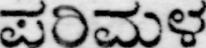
ಪರಿಮಳ
